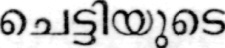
ചെട്ടിയുടെ
